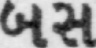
બસ
